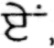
ਏਂ,
